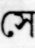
সে
